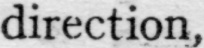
direction,
